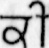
ਕੀ
